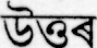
উত্তৰ
